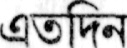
এতদিন
